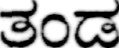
ತಂಡ
